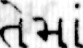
તેમાં
